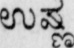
ಉಷ್ಣ
